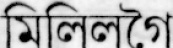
মিলিলগৈ
